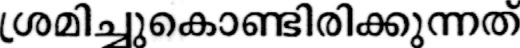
ശ്രമിച്ചുകൊണ്ടിരിക്കുന്നത്
